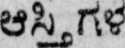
ಆಸ್ತಿಗಳ
